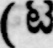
(ಟ
